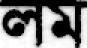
লম
